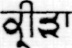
ਕ੍ਰੀੜਾ
